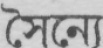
সৈন্যে
